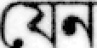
যেন
